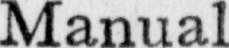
Manual
